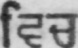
ਵਿਚ
